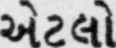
એટલો
